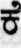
ಕೆ
